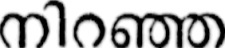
നിറഞ്ഞ
